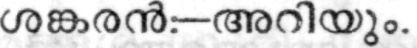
ശങ്കരന്‍:-അറിയും.
